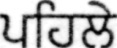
ਪਹਿਲੇ
